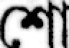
শো
